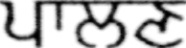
ਪਾਲਣ
